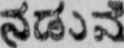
ನಡುವೆ
